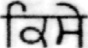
ਕਿਸੇ
